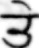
ਤੇ
